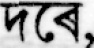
দৰে,
